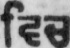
ਵਿਚ
